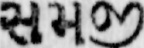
સમજી
